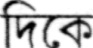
দিকে
